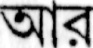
আর
